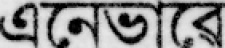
এনেভাৱে
